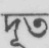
দূত
